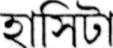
হাসিটা
